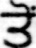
ਤੋਂ
